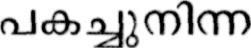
പകച്ചുനിന്ന
